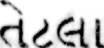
તેટલા
